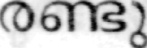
രണ്ടു
